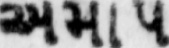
અમાપ
